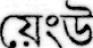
য়েংউ
